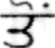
ਤੋਂ
